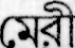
মেরী
